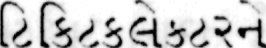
ટિકિટકલેક્ટરને
